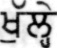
ਖੁੱਲ੍ਹੇ
